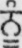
ਨੂੰ
